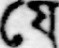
যে
